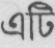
এটি
